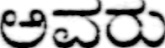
ಅವರು
